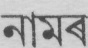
নামৰ
